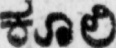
ಕೂಲಿ
